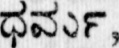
ಧರ್ಮ,
